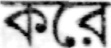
করে
